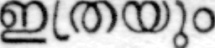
ഇത്രയും
